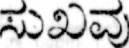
ಸುಖವು
